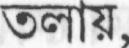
তলায়,
